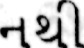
નથી
